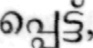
പ്പെട്ട്,
